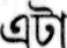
এটা
